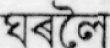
ঘৰলৈ
